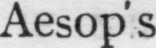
Aesop's
